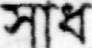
সাধ
